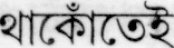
থাকোঁতেই
